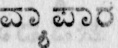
ವ್ಯಾಪಾರ
